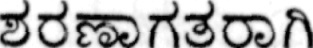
ಶರಣಾಗತರಾಗಿ
